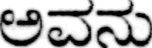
ಅವನು
